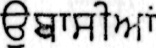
ਉਬਾਸੀਆਂ
